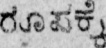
ರೂಪಕ್ಕೆ
